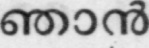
ഞാന്‍
